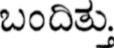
ಬಂದಿತ್ತು.
